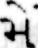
મેં
